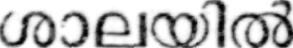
ശാലയില്‍
